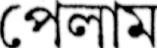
পেলাম
